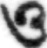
ও
